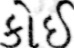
કોઈ
